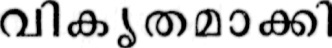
വികൃതമാക്കി
